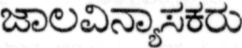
ಜಾಲವಿನ್ಯಾಸಕರು
